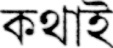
কথাই
